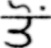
ਤੋਂ
